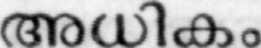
അധികം
